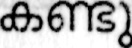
കണ്ടു
